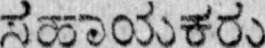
ಸಹಾಯಕರು
